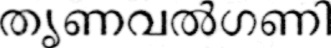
തൃണവല്‍ഗണി
